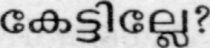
കേട്ടില്ലേ?
